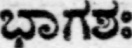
ಭಾಗಶಃ
